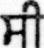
ਸੀ
